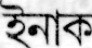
ইনাক
